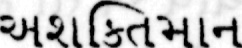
અશક્તિમાન
